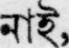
নাই,
